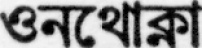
ওনথোক্না
